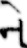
ને
